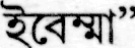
ইবেম্মা”
